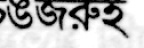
চঙজরুই
